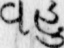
વહુ
